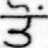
ਤੋਂ
